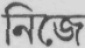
নিজে
